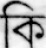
কি
